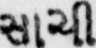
સાચી
